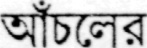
আঁচলের
